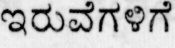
ಇರುವೆಗಳಿಗೆ
